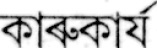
কাৰুকার্য
